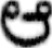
ಆ
